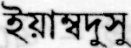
ইয়াম্বদুসু
